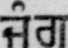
ਜੰਗ
